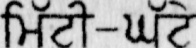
ਮਿੱਟੀ-ਘੱਟੇ
